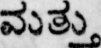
ಮತ್ತು
